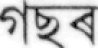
গছৰ
